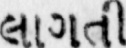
લાગતી
